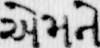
એમને
